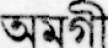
অমগী
